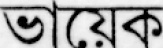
ভায়েক
